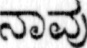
ನಾವು
